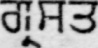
ਗ੍ਰਸਤ
